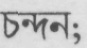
চন্দন;
